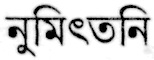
নুমিৎতনি
